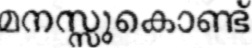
മനസ്സുകൊണ്ട്
